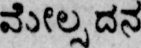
ಮೇಲ್ಸದನ
